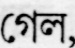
গেল,
